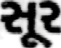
સૂર
